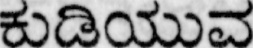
ಕುಡಿಯುವ
